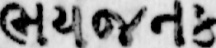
ભયજનક
